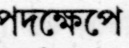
পদক্ষেপে
